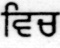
ਵਿਚ
